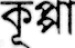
কূপ্পা
